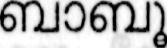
ബാബൂ
